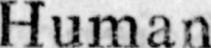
Human
